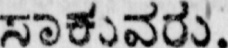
ಸಾಕುವರು.
